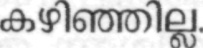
കഴിഞ്ഞില്ല.
